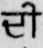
ਦੀ
